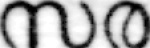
സര
